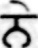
ਨੇ
